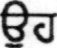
ਉਹ
